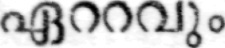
ഏററവും
